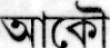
আকৌ
